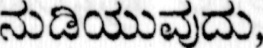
ನುಡಿಯುವುದು,
